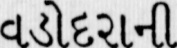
વડોદરાની
